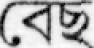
বেছ
